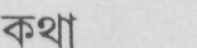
কথা
